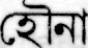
হৌনা
